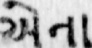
એના
